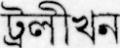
ট্রলীখন
